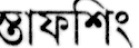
স্তাফশিং
